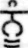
ਨੂੰ
